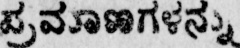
ಪ್ರಮಾಣಗಳನ್ನು
